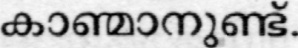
കാണ്മാനുണ്ട്.
